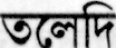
তলেদি
